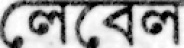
লেবেল
